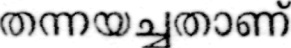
തന്നയച്ചതാണ്
